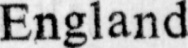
England
